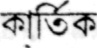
কার্তিক
